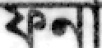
ফনা
